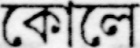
কোলে
